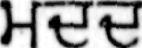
ਮਦਦ
